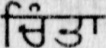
ਚਿੰਤਾ
